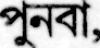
পুনবা,
